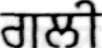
ਗਲੀ
